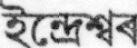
ইন্দ্রেশ্বৰ
